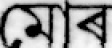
মোৰ
